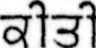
ਕੀਤੀ
